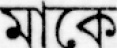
মাকে
